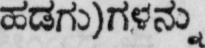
ಹಡಗು)ಗಳನ್ನು
